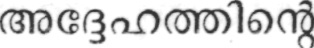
അദ്ദേഹത്തിന്റെ
